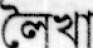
লৈখা
